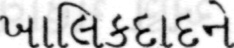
ખાલિકદાદને
